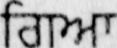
ਗਿਆ
